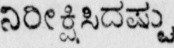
ನಿರೀಕ್ಷಿಸಿದಷ್ಟು
